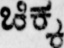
ಚಿಕ್ಕ
